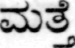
ಮತ್ತೆ
